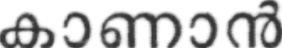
കാണാന്‍
